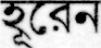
হূরেল
